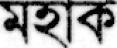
মহাক
